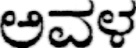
ಅವಳ
